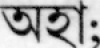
অহা;
